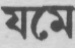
যমে
